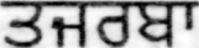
ਤਜਰਬਾ
